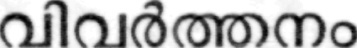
വിവര്‍ത്തനം
